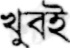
খুবই
